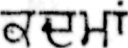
ਕਦਮਾਂ
